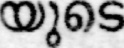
യുടെ
